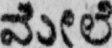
ಮೇಲೆ
